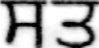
ਸਤ
